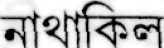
নাথাকিল
